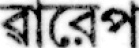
ৱারেপ
